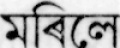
মৰিলে
